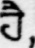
ਹੈ,
